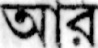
আর
